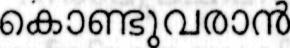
കൊണ്ടുവരാന്‍
